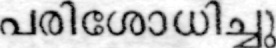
പരിശോധിച്ചു
